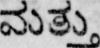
ಮತ್ತು
